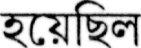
হয়েছিল
